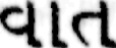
વાત
